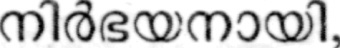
നിര്‍ഭയനായി,
